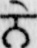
ਨੇ
